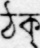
ঠক্
